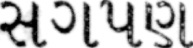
સગપણ
